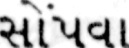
સોંપવા
